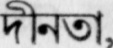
দীনতা,
